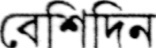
বেশিদিন
